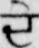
ਦੇ
